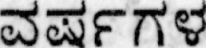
ವರ್ಷಗಳ
